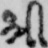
શ્રી
